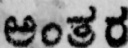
ಅಂತರ
